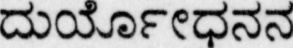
ದುರ್ಯೋಧನನ
